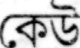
কেউ
